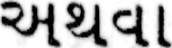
અથવા
